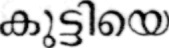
കുട്ടിയെ
